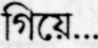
গিয়ে...
